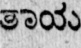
ತಾಯ
